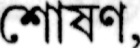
শোষণ,
